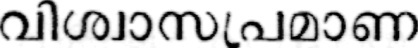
വിശ്വാസപ്രമാണ
